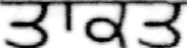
ਤਾਕਤ
